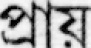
প্রায়
